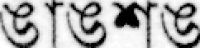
ঙাঙশঙ
